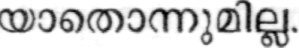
യാതൊന്നുമില്ല.
